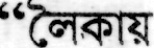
“লৈকায়
